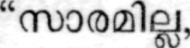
“സാരമില്ല,
